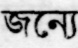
জন্যে
